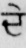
ਦੇ
